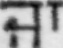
ਜਾ
